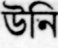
উনি
